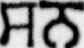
ਸਨ
